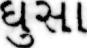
ઘુસા
